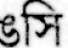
ঙসি
